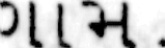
ગામ.
